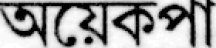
অয়েকপা
